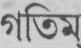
গতিম্‌
